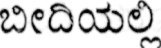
ಬೀದಿಯಲ್ಲಿ
